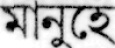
মানুহে
